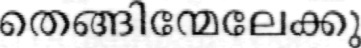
തെങ്ങിന്മേലേക്കു
